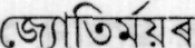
জ্যোতির্ময়ৰ
